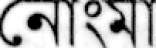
নোংমা
